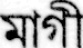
মাগী
